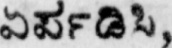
ಏರ್ಪಡಿಸಿ,
